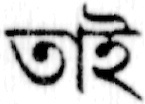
তাই
